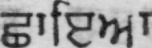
ਛਾਇਆ
